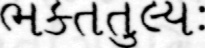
ભક્તતુલ્યઃ
